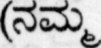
(ನಮ್ಮ
